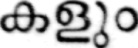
കളും
